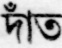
দাঁত
